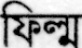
ফিল্ম
